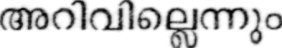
അറിവില്ലെന്നും
